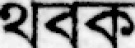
থবক
